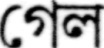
গেল
